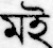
মই
